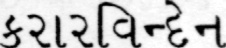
કરારવિન્દેન
